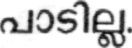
പാടില്ല.
